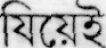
যিয়েই
